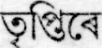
তৃপ্তিৰে
